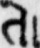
તો
